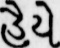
હૈયે
